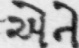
એને
